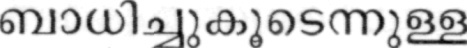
ബാധിച്ചുകൂടെന്നുള്ള
